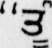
''ਤੂੰ
